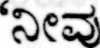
‘ನೀವು
